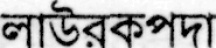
লাউরকপদা
